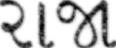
રાજા
